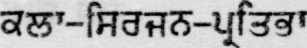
ਕਲਾ-ਸਿਰਜਨ-ਪ੍ਰਤਿਭਾ
